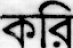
করি
